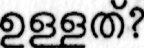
ഉള്ളത്?
